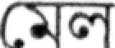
মেল
